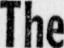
The
